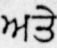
ਅਤੇ
